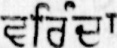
ਵਰਿੰਦਾ
